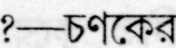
?–চণকের
